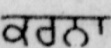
ਕਰਨਾ
